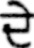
ਦੇ
